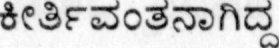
ಕೀರ್ತಿವಂತನಾಗಿದ್ದ
